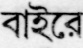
বাইরে
